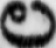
ಲ
